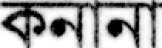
হূরেল
